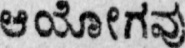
ಆಯೋಗವು
